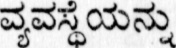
ವ್ಯವಸ್ಥೆಯನ್ನು
